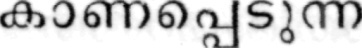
കാണപ്പെടുന്ന
